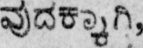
ವುದಕ್ಕಾಗಿ,
